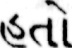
હતો
